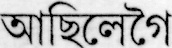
আছিলেগৈ
